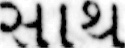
સાથ
